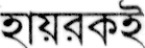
হায়রকই
